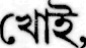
খোই,
